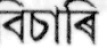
বিচাৰি
